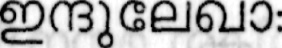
ഇന്ദുലേഖാ:
